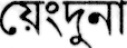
য়েংদুনা
